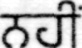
ਨਹੀਂ
